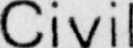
Civil
